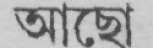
আছো
